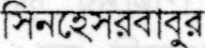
সিনহেসরবাবুর
